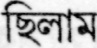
ছিলাম
